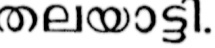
തലയാട്ടി.
